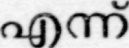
എന്ന്
